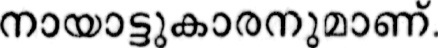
നായാട്ടുകാരനുമാണ്.
